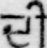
ਦੀ
